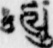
કહ્યું
